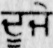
ਦੂਜੇ
